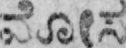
ಮೋಸ
